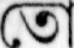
তো
